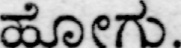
ಹೋಗು.
